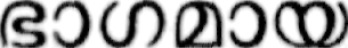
ഭാഗമായ
